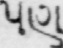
પણ
